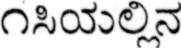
೧ಸಿಯಲ್ಲಿನ
